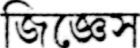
জিজ্ঞেস
